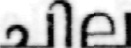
ചില
